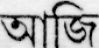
আজি
